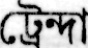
ট্রেন্দা
